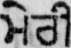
ਮੇਰੀ
